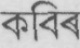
কবিৰ
